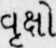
વૃક્ષો
